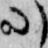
ಎ)
